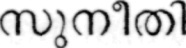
സുനീതി
